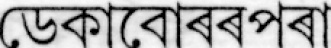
ডেকাবোৰৰপৰা
